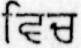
ਵਿਚ
